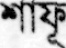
শাফূ
